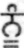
ਨੂੰ
